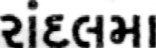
રાંદલમા
